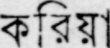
করিয়া
